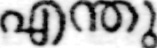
എന്തു
